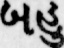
બહુ
